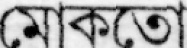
মোকতো
